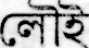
লৌই
